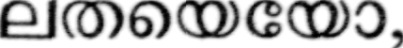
ലതയെയോ,
